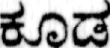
ಕೂಡ
